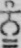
ਨੂੰ
